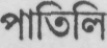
পাতিলি
